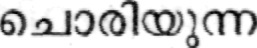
ചൊരിയുന്ന
